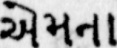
એમના
